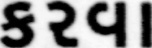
કરવા
